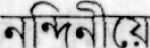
নন্দিনীয়ে
